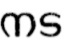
നട
